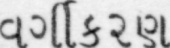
વર્ગીકરણ
